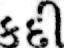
કદી
